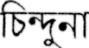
চিন্দুনা
